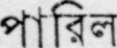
পারিল
